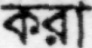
করা
